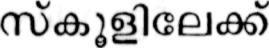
സ്കൂളിലേക്ക്
